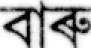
বাৰু
